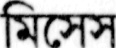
মিসেস
